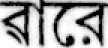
ৱারে
